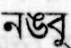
নঙবু
